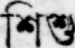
শিশু
